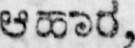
ಆಹಾರ,
